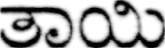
ತಾಯಿ
